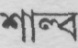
শালব
